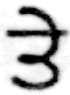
ਤੇ
